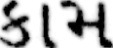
કામ
